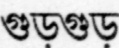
গুড়গুড়
